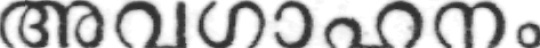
അവഗാഹനം
